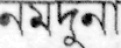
নমদুনা
